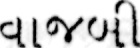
વાજબી
